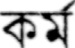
কর্ম
